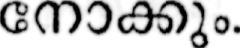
നോക്കും.
